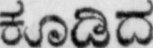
ಕೂಡಿದ
